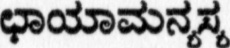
ಛಾಯಾಮನ್ಯಸ್ಕ
